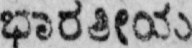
ಭಾರತೀಯ
